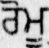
ਰੋਮੂ
